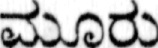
ಮೂರು
